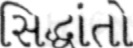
સિદ્ધાંતો
